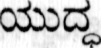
ಯುದ್ಧ
